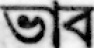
ভাব
